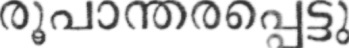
രൂപാന്തരപ്പെട്ടു
